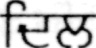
ਦਿਲ
